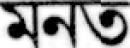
মনত
